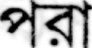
পরা
